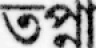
তপ্না
